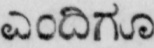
ಎಂದಿಗೂ
